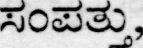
ಸಂಪತ್ತು,
